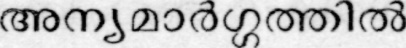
അന്യമാര്‍ഗ്ഗത്തില്‍
